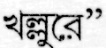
খল্লুরে”
